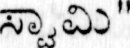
ಸ್ವಾಮಿ”
